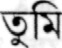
তুমি
